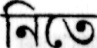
নিতে
